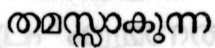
തമസ്സാകുന്ന
